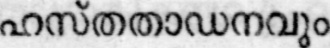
ഹസ്തതാഡനവും
